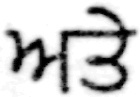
ਅਤੇ
